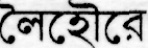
লৈহৌরে
